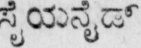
ಸೈಯನೈಡ್
